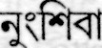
নুংশিবা
